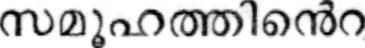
സമൂഹത്തിന്റെ
